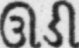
ઊડી
